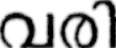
വരി
